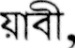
য়াবী,
